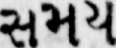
સમય
